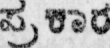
ಪ್ರಕಾರ
